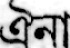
ঐনা
